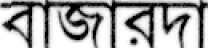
বাজারদা
